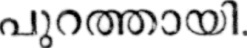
പുറത്തായി.
